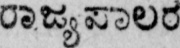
ರಾಜ್ಯಪಾಲರ
